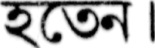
হতেন।
